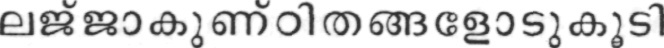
ലജ്ജാകുണ്ഠിതങ്ങളോടുകൂടി
